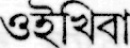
ওইখিবা
